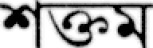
শক্তম
